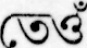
তেওঁ
